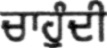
ਚਾਹੁੰਦੀ
